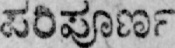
ಪರಿಪೂರ್ಣ
